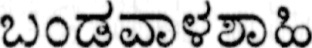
ಬಂಡವಾಳಶಾಹಿ
